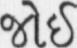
જોઈ
